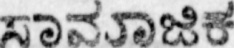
ಸಾಮಾಜಿಕ
